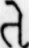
તે
